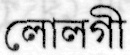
লোলগী
